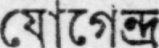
যোগেন্দ্র
